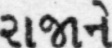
રાજાને
